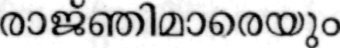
രാജ്ഞിമാരെയും
